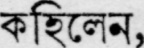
কহিলেন,
